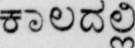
ಕಾಲದಲ್ಲಿ
